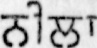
ਨੀਲਾ
